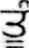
ਤੂੰ
